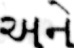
અને
